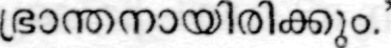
ഭ്രാന്തനായിരിക്കും.’
